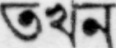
তখন
